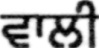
ਵਾਲੀ
